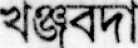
খঞ্জবদা
